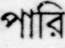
পারি
